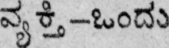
ವ್ಯಕ್ತಿ-ಒಂದು
